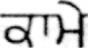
ਕਾਮੇ
